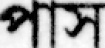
পাস
